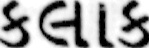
કલાક
